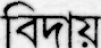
বিদায়
